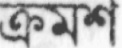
ক্রমশ
